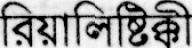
রিয়ালিষ্টিক্কী
